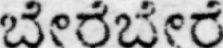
ಬೇರೆಬೇರೆ
